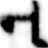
ન
